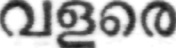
വളരെ
